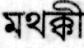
মথক্কী
